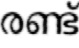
രണ്ട്
